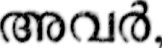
അവര്‍,
